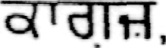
ਕਾਗ਼ਜ਼,
